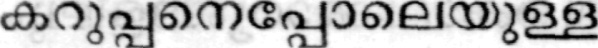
കറുപ്പനെപ്പോലെയുള്ള
